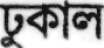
ঢুকাল
